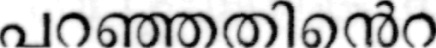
പറഞ്ഞതിന്റെ
